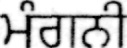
ਮੰਗਨੀ
